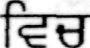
ਵਿਚ
